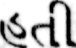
હતી
